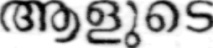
ആളുടെ
